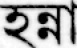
হন্না
